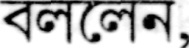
বললেন,
